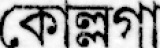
কোল্লগা
